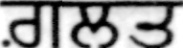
ਗ਼ਲਤ
